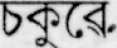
চকুৱে
